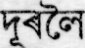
দূৰলৈ
